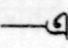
–এ
